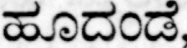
ಹೂದಂಡೆ,
